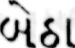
બેઠા
